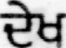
ਦੇਖ
